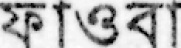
ফাওবা
